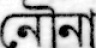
নৌনা
